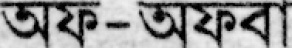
অফ-অফবা
